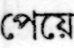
পেয়ে
